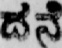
ದನೆ
